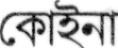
কোইনা
